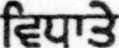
ਵਿਧਾਤੇ
